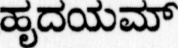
ಹೃದಯಮ್
